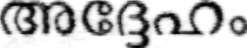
അദ്ദേഹം
